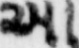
આ
